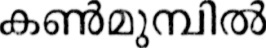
കണ്‍മുമ്പില്‍
